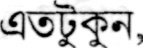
এতটুকুন,
